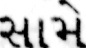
સામે
